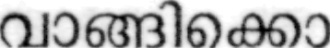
വാങ്ങിക്കൊ
